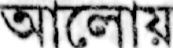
আলোয়
